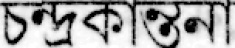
চন্দ্রকান্তনা
